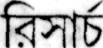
রিসার্চ
